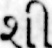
શી
